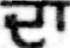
ਦਾ
